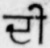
ਦੀ
